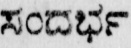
ಸಂದರ್ಭ
